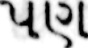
પણ
